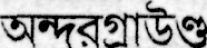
অন্দরগ্রাউণ্ড
